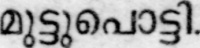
മുട്ടുപൊട്ടി.
